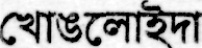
খোঙলোইদা
